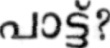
പാട്ട്?
